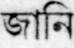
জানি
